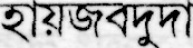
হায়বজদুদা
